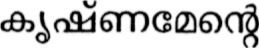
കൃഷ്ണമേന്റെ
